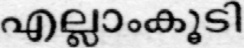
എല്ലാംകൂടി
